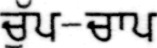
ਚੁੱਪ-ਚਾਪ
